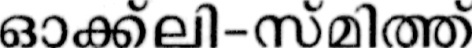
ഓക്ക്ലി-സ്മിത്ത്
